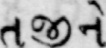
તજીને
